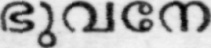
ഭുവനേ
